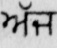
ਅੱਜ
